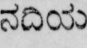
ನದಿಯ
